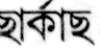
ছার্কাছ
